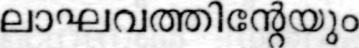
ലാഘവത്തിന്റേയും
